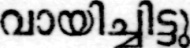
വായിച്ചിട്ടു
